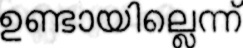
ഉണ്ടായില്ലെന്ന്
